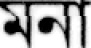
মনা
